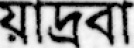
য়াদ্রবা
